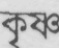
কৃষ্ণ
